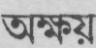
অক্ষয়
